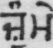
ਜ਼ੁੰਮੇ
